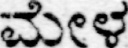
ಮೇಳ
